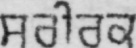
ਸਰੀਰਕ
